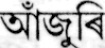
আঁজুৰি
